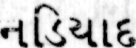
નડિયાદ
